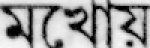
মখোয়
